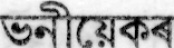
ভনীয়েকৰ
